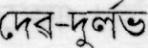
দেৱ-দুর্লভ
